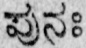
ಪುನಃ
